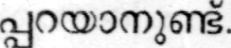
പ്പറയാനുണ്ട്.
